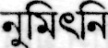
নুমিৎনি
